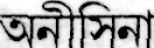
অনীসিনা
